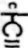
ਨੂੰ
